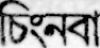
চিংনবা
